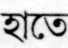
হাতে
